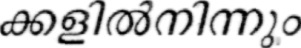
ക്കളില്‍നിന്നും
